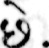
છે.
